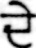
ਦੇ
